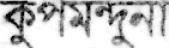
কুপমন্দুনা
